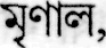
মৃণাল,
